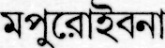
মপুরোইবনা
